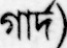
গার্দ)
